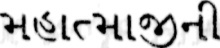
મહાત્માજીની
